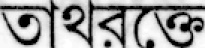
তাথরক্তে
